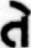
તે
